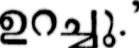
ഉറച്ചു.’
